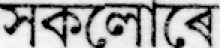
সকলোৰে
